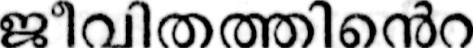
ജീവിതത്തിന്റെ
